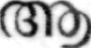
ആ
